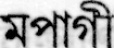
মপাগী
